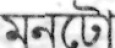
মনটো
